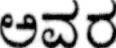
ಅವರ
